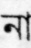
না
